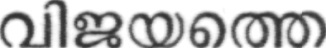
വിജയത്തെ
